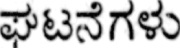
ಘಟನೆಗಳು
